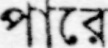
পারে
